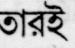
তারই
